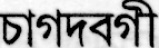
চাগদবগী
